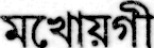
মখোয়গী
